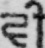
ਵੀ
